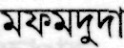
মফমদুদা
